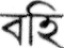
বহি
